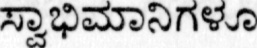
ಸ್ವಾಭಿಮಾನಿಗಳೂ
